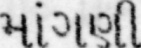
માંગણી
